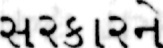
સરકારને
